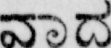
ವಾದ
